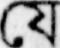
যে
